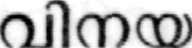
വിനയ
